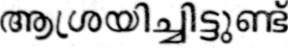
ആശ്രയിച്ചിട്ടുണ്ട്
